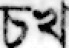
চখ
